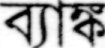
ব্যাঙ্ক
